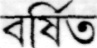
বর্ষিত
